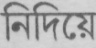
নিদিয়ে
